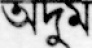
অদুম
